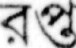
রপ্ত
